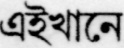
এইখানে
